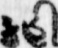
કહી
